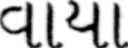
વાયા
